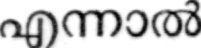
എന്നാല്‍
